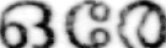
ഒരേ
